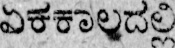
ಏಕಕಾಲದಲ್ಲಿ
